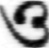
ও
